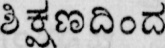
ಶಿಕ್ಷಣದಿಂದ
